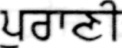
ਪੁਰਾਣੀ
